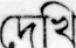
দেখি
